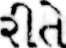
રીતે
